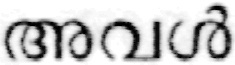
അവള്‍
